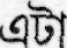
এটা
